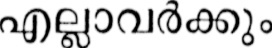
എല്ലാവര്‍ക്കും
